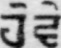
ਹੋਵੇ
